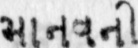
માનવની
